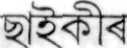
ছাইকীৰ
